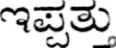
ಇಪ್ಪತ್ತು
